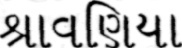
શ્રાવણિયા
